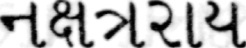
નક્ષત્રરાય
